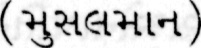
(મુસલમાન)
